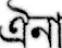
ঐনা
